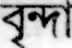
বৃন্দা
